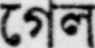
গেল
